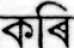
কৰি
